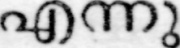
എന്നു
